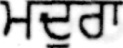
ਮਦੁਰਾ
